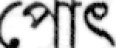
পোৎ
